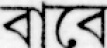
বাবে
